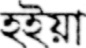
হইয়া
